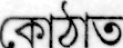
কোঠাত
